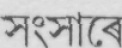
সংসাৰে
